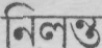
নিলন্ত
